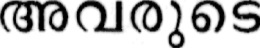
അവരുടെ
